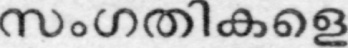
സംഗതികളെ
